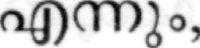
എന്നും,
